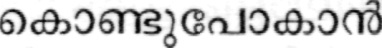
കൊണ്ടുപോകാന്‍
